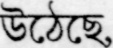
উঠেছে,
